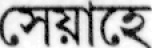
সেয়াহে
